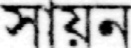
সায়ন
